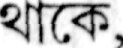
থাকে,
